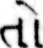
તો
